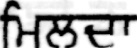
ਮਿਲਦਾ
